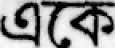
একে
